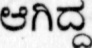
ಆಗಿದ್ದ
